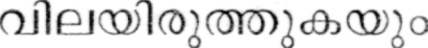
വിലയിരുത്തുകയും
